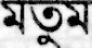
মতুম
